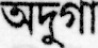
অদুগা
